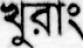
খুরাং
